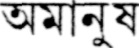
অমানুষ
